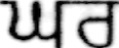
ਘਰ
